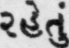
રહેતું
